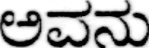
ಅವನು
